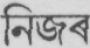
নিজৰ
